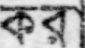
করা
